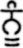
ਨੂੰ
